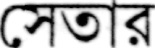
সেতার
